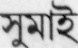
সুমাই
